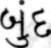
બુંદ
